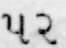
પર
